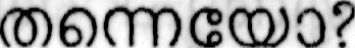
തന്നെയോ?
